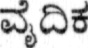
ವೈದಿಕ
